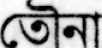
তৌনা
